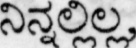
ನಿನ್ನಲ್ಲಿಲ್ಲ,
